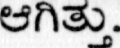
ಆಗಿತ್ತು.
